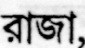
রাজা,
